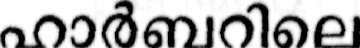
ഹാര്‍ബറിലെ
